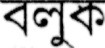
বলুক
